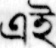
এই
